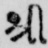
શ્રી
